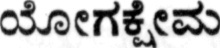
ಯೋಗಕ್ಷೇಮ
